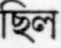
ছিল
